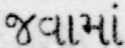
જવામાં
